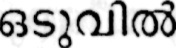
ഒടുവില്‍
